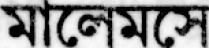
মালেমসে
